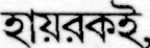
হায়রকই,
